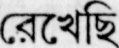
রেখেছি
